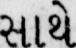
સાથે
